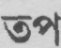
তপ
